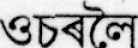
ওচৰলৈ
